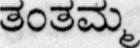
ತಂತಮ್ಮ
